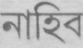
নাহিব
